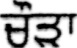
ਚੌੜਾ
